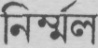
নিৰ্ম্মল
